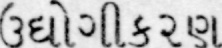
ઉદોગીકરણ
